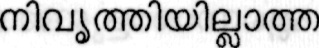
നിവൃത്തിയില്ലാത്ത
